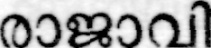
രാജാവി
